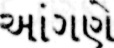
આંગણે
